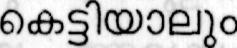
കെട്ടിയാലും
